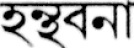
হন্থবনা
